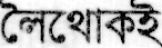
লৈথোকই
